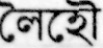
লৈহৌ
